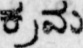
ಕ್ರಮ
